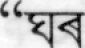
"ঘৰ
